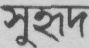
সুহৃদ
